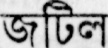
জটিল
